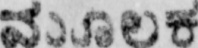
ಮೂಲಕ
